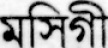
মসিগী
